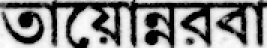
তায়োন্নরবা
